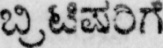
ಬ್ರಿಟಿಷರಿಗೆ
